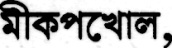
মীকপখোল,
